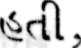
હતી,
